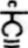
ਨੂੰ
